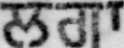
ਲਗਾ
